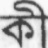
কী
